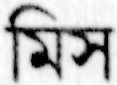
মিস
